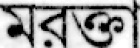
মরক্তা
